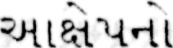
આક્ષેપનો
